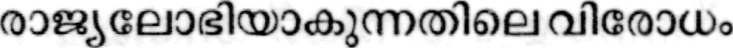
രാജ്യലോഭിയാകുന്നതിലെവിരോധം
